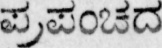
ಪ್ರಪಂಚದ
